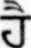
ਹੈ
